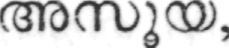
അസൂയ,
